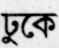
ঢুকে
